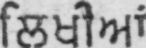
ਲਿਖੀਆਂ
